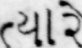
ત્યારે
